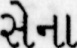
સેના
